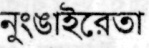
নুংঙাইরেতা
